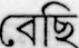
বেছি
